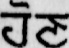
ਹੋਣ
